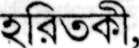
হরিতকী,
